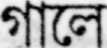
গালে
